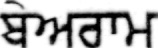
ਬੇਅਰਾਮ
